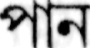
পান
